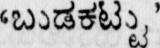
‘ಬುಡಕಟ್ಟು’
